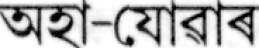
অহা-যোৱাৰ
